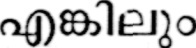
എങ്കിലും
